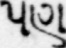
પણ
